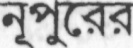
নূপুরের
